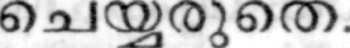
ചെയ്യരുതെ.
